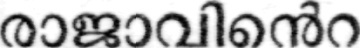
രാജാവിന്റെ
